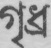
গৃধ্র
